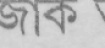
জাক
